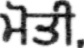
ਮੋਤੀ,
